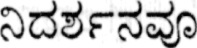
ನಿದರ್ಶನವೂ
